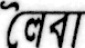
লৈবা
